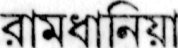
রামধানিয়া
